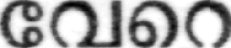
വേറെ
